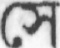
সে
